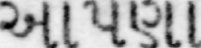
આપણા
